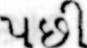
પછી
